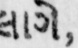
લાગે,
